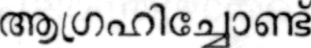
ആഗ്രഹിച്ചോണ്ട്
